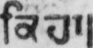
ਕਿਹਾ।
